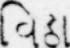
વિઠા
